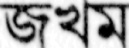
জখম
